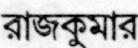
রাজকুমার
